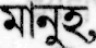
মানুহ,
